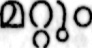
മറ്റും
